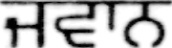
ਜਵਾਨ
